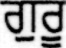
ਗੁਰੂ
